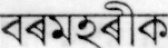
বৰমহৰীক
